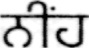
ਨੀਂਹ
